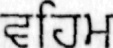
ਵਹਿਮ
